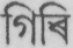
গিৰি
